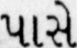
પાસે
